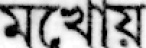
মখোয়
